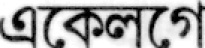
একেলগে
